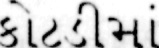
કોટડીમાં
